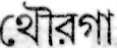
থৌরগা
